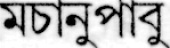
মচানুপাবু
